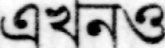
এখনও
